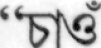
"চাওঁ
